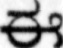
ಈ
